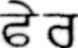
ਫੇਰ
